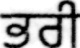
ਭਰੀ
